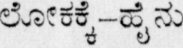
ಲೋಕಕ್ಕೆ-ಹೈನು
